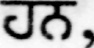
ਹਨ,
